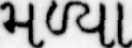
મળ્યા
